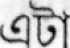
এটা
